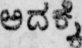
ಅದಕ್ಕೆ
